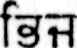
ਭਿਜ
